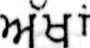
ਅੱਖਾਂ
